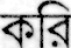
করি
